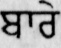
ਬਾਰੇ
